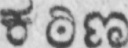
ಕಠಿಣ
